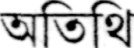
অতিথি
